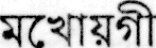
মখোয়গী
